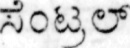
ಸೆಂಟ್ರಲ್
